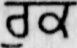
ਰੁਕ
